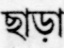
ছাড়া
